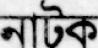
নাটক
